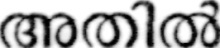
അതില്‍
